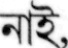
নাই,
